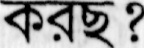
করছ?
